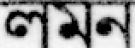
লমন
